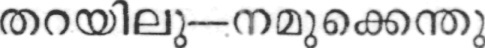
തറയിലു-നമുക്കെന്തു
